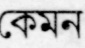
কেমন
